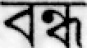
বন্ধ
